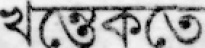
খন্তেকতে
